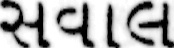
સવાલ
